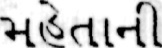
મહેતાની
